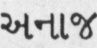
અનાજ
